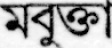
মবু্ক্তা
